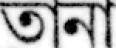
তানা
